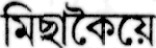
মিছাকৈয়ে
